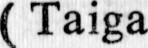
(Taiga
